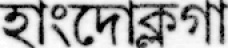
হাংদোক্লগা
